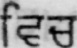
ਵਿਚ
